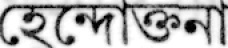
হেন্দোক্তনা
